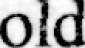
old
